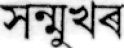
সন্মুখৰ
